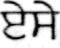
ਏਸੇ
